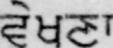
ਵੇਖਣਾ
